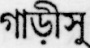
গাড়ীসু
